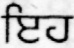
ਇਹ
